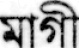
মাগী
